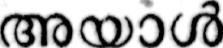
അയാള്‍
